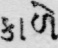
કાળે
